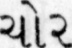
ચોર
